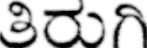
ತಿರುಗಿ
